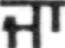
ਜਾ
